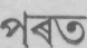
পৰত
